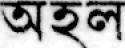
অহল
